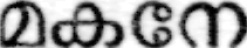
മകനേ
